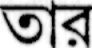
তার
